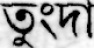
তুংদা
